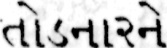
તોડનારને
